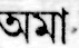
অমা
